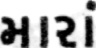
મારાં
